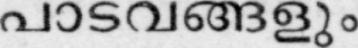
പാടവങ്ങളും
